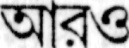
আরও
